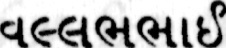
વલ્લભભાઈ
